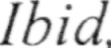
Ibid,
